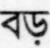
বড়
